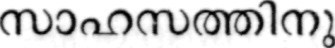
സാഹസത്തിനു
